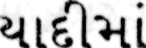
યાદીમાં
